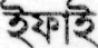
ইফাই
